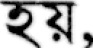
হয়,
